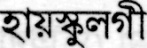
হায়স্কুলগী
